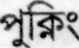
পুক্নিং
